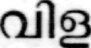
വിള
